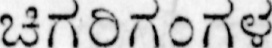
ಚಿಗರಿಗಂಗಳ
